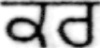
ਕਰ
